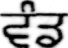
ਵੰਡ
